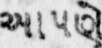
આપણે
